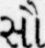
સૌ
